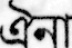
ঐনা
